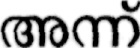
അന്ന്
